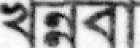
খন্নবা
